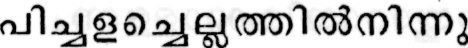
പിച്ചളച്ചെല്ലത്തില്‍നിന്നു
